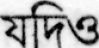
যদিও
